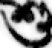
শু
